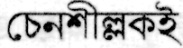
চেনশীল্লকই
